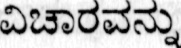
ವಿಚಾರವನ್ನು
